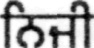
ਨਿਜੀ
